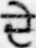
ਦੇ
